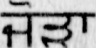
ਜੋੜਾ
